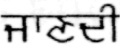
ਜਾਣਦੀ
